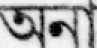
অনা
